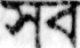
সব
